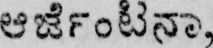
ಅರ್ಜೆಂಟಿನಾ,
